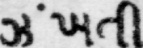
ઝંખતી
